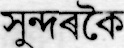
সুন্দৰকৈ
